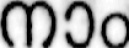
നാം
